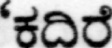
‘ಕದಿರೆ
